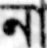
না
